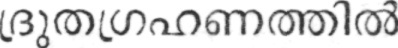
ദ്രുതഗ്രഹണത്തില്‍
